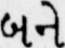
બને
